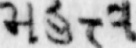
મહત્વ
